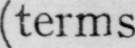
(terms
